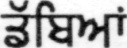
ਡੱਬਿਆਂ
